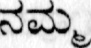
ನಮ್ಮ
